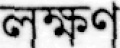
লক্ষণ
